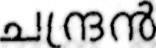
ചന്ദ്രന്‍
